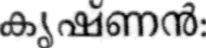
കൃഷ്ണന്‍:
